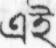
এই
